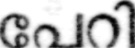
പേറി
